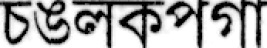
চঙলকপগা
